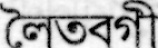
লৈতবগী
